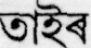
তাইৰ
